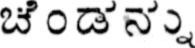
ಚೆಂಡನ್ನು
